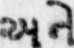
અને
